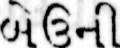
બેઉની
